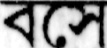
বসে
